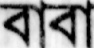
বাবা
